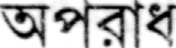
অপরাধ
